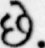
છે.
